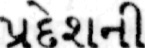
પ્રદેશની
